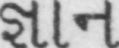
જ્ઞાન
